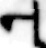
ન
